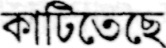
কাটিতেছে
